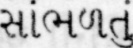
સાંભળતું
